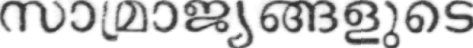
സാമ്രാജ്യങ്ങളുടെ
